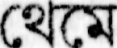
থেমে
